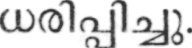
ധരിപ്പിച്ചു.
